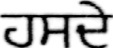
ਹਸਦੇ
